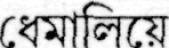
ধেমালিয়ে
